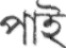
পাই
